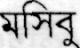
মসিবু
